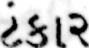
ટંકાર
